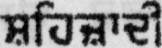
ਸ਼ਹਿਜ਼ਾਦੀ
